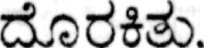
ದೊರಕಿತು.
